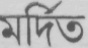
মর্দিত
